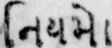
નિયમો
